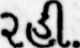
રહી.
